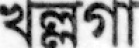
খল্লগা
